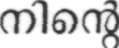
നിന്റെ
